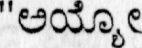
“ಅಯ್ಯೋ
